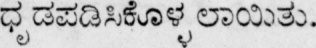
ಧೃಡಪಡಿಸಿಕೊಳ್ಳಲಾಯಿತು.
